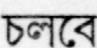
চলবে
